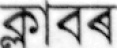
ক্লাবৰ
